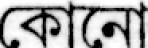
কোনো
